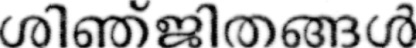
ശിഞ്ജിതങ്ങള്‍
